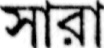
সারা
